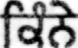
ਕਿੰਨੇ
